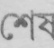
শেষ
